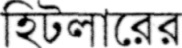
হিটলারের
